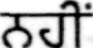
ਨਹੀਂ
